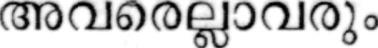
അവരെല്ലാവരും
